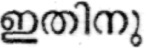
ഇതിനു
